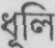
ধূলি
